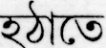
হঠাতে
